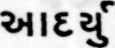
આદર્યુ
